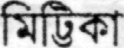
মিট্টিকা
